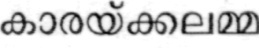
കാരയ്ക്കലമ്മ
